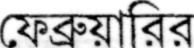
ফেব্রুয়ারির
